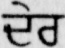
ਦੇਰ
